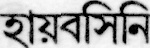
হায়বসিনি
